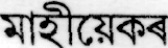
মাহীয়েকৰ
